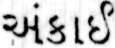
અંકાઈ
